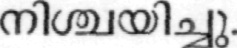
നിശ്ചയിച്ചു.
